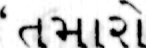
'તમારો
